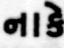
નાકે
